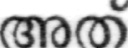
അത്
